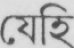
যেহি
